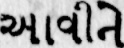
આવીને
